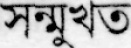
সন্মুখত
